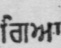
ਗਿਆ
